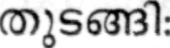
തുടങ്ങി:
